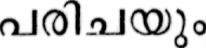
പരിചയും
